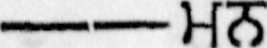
------.ਮਨ
